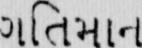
ગતિમાન
